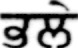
ਭਲੇ
